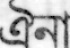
ঐনা
